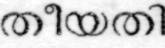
തീയതി
